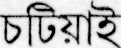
চটিয়াই
